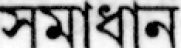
সমাধান
